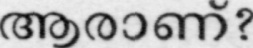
ആരാണ്?
